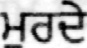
ਮੁਰਦੇ
